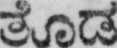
ತೊಡ
